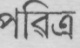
পৱিত্র
